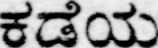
ಕಡೆಯ
